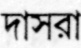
দাসরা
